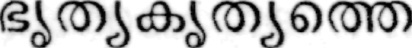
ഭൃത്യകൃത്യത്തെ
